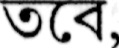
তবে,
